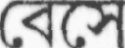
বেসে
